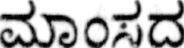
ಮಾಂಸದ
